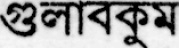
গুলাবকুম
